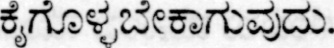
ಕೈಗೊಳ್ಳಬೇಕಾಗುವುದು.
